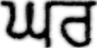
ਘਰ
